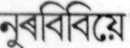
নুৰবিবিয়ে
